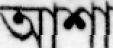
আশা
